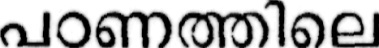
പഠണത്തിലെ
